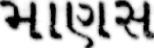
માણસ
